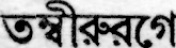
তম্বীরুরগে
